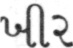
ખીર
